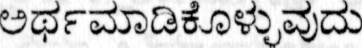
ಅರ್ಥಮಾಡಿಕೊಳ್ಳುವುದು
